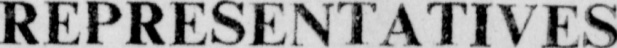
REPRESENTATIVES
